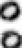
ঃ
